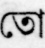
তো
